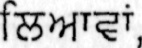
ਲਿਆਵਾਂ,
